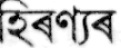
হিৰণ্যৰ
